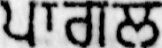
ਪਾਗਲ
